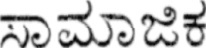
ಸಾಮಾಜಿಕ
